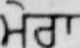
ਮੇਰਾ
